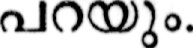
പറയും.
